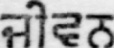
ਜੀਵਨ
